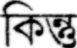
কিন্তু
